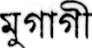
মুগাগী
